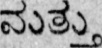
ಮತ್ತು
